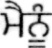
ਮੈਨੂੰ
